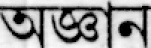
অজ্ঞান
